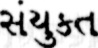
સંયુક્ત
